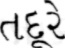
તદૂરે
